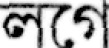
লগে
